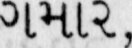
ગમાર,
